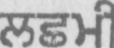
ਲਛਮੀ
